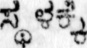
ಸ್ಥಳಕ್ಕೆ
